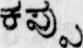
ಕಪ್ಪು
